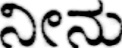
ನೀನು
